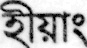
হীয়াং
